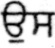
ਉਸ
